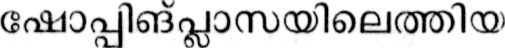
ഷോപ്പിങ്പ്ലാസയിലെത്തിയ
